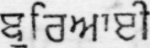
ਬੁਰਿਆਈ
